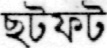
ছটফট
